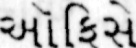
ઑફિસે
